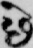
છે
